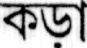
কড়া
